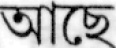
আছে
